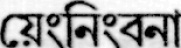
য়েংনিংবনা
